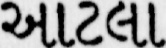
આટલા
